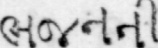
ભજનની
